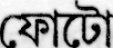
ফোটো
